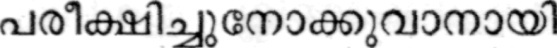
പരീക്ഷിച്ചുനോക്കുവാനായി
